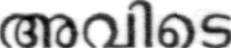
അവിടെ
